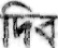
দিব
